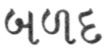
બળદ
